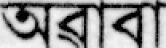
অৱাবা
